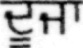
ਦੂਜਾ
